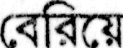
বেরিয়ে
